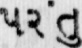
પરંતુ
